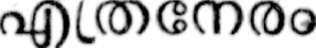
എത്രനേരം
